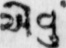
એવું
